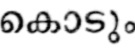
കൊടും
